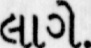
લાગે.
